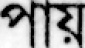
পায়
